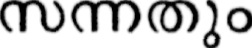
സന്നതും
